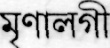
মৃণালগী
